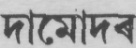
দামোদৰ
